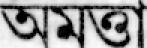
অমত্তা
